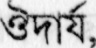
ঔদার্য,
